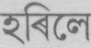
হৰিলে
